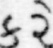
કરે
